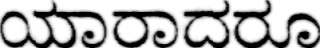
ಯಾರಾದರೂ
